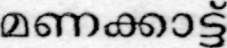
മണക്കാട്ട്
